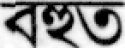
বহুত
